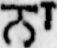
ਨਾ
